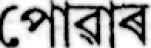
পোৱাৰ
